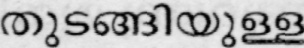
തുടങ്ങിയുള്ള
